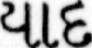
યાદ
